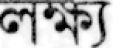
লক্ষ্য
